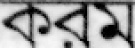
করম
